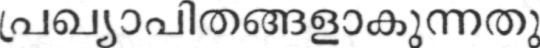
പ്രഖ്യാപിതങ്ങളാകുന്നതു
